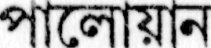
পালোয়ান
